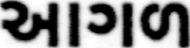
આગળ
